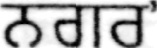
ਨਗਰ'
